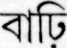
বাঢ়ি
